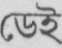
ডেই
